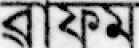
ৱাফম
